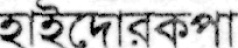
হাইদোরকপা
